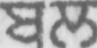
ਬਲ
